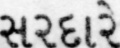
સરદારે
